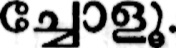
ച്ചോളൂ.
